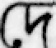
দে
